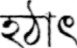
হঠাত্
